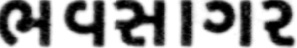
ભવસાગર
